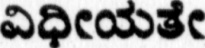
ವಿಧೀಯತೇ
